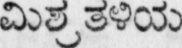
ಮಿಶ್ರತಳಿಯ
